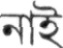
নাই
